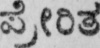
ಪ್ರೇರಿತ
